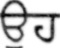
ਉਹ
